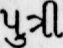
પુત્રી
